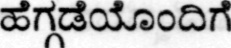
ಹೆಗ್ಗಡೆಯೊಂದಿಗೆ
